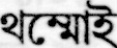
থম্মোই
